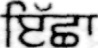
ਇੱਛਾ
